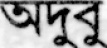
অদুবূ
